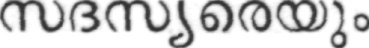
സദസ്യരെയും
